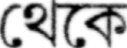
থেকে
